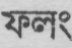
ফলং
